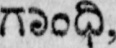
ಗಾಂಧಿ,
